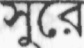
সুরে
